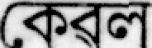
কেৱল
